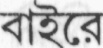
বাইরে
